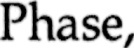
Phase,
